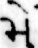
મેં
